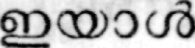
ഇയാള്‍
